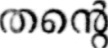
തന്റെ
